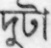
দুটা
